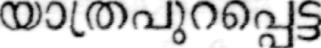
യാത്രപുറപ്പെട്ട
